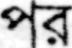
পর
